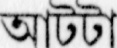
আটটা
